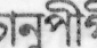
নুপীগী
